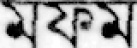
মফম
